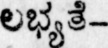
ಲಭ್ಯತೆ-
